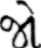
જો
